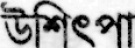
উশিৎপা
